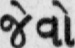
જેવો
